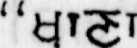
''ਖਾਣਾ
